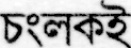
চংলকই
